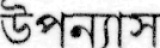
উপন্যাস
